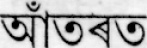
আঁতৰত
